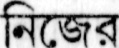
নিজের
